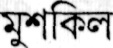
মুশকিল
